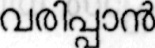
വരിപ്പാന്‍
